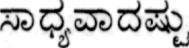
ಸಾಧ್ಯವಾದಷ್ಟು
